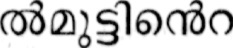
ല്‍മുട്ടിന്റെ
